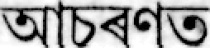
আচৰণত
